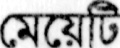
মেয়েটি
